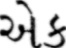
એક
